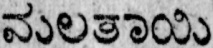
ಮಲತಾಯಿ
